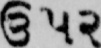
ઉપર
